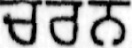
ਚਰਨ
